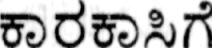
ಕಾರಕಾಸಿಗೆ
